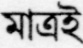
মাত্রই
